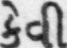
કેવી
